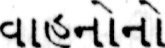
વાહનોનો
